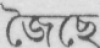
জৈছে
